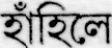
হাঁহিলে
